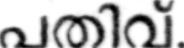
പതിവ്.
